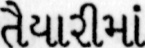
તૈયારીમાં
